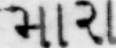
મારા
